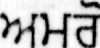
ਅਮਰੋ
